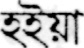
হইয়া
